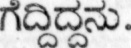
ಗೆದ್ದಿದ್ದನು.
